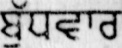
ਬੁੱਧਵਾਰ
